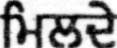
ਮਿਲਦੇ
